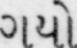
ગયો
